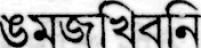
ঙমজখিবনি
